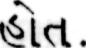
હોત.
